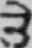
ਤੇ
